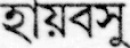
হায়বসু
